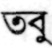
তবু
